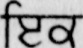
ਇਕ
